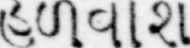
હળવાશ
